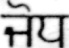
ਜੋਧ
